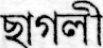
ছাগলী
